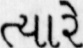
ત્યારે
